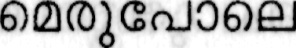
മെരുപോലെ
